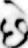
છે
